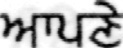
ਆਪਣੇ
